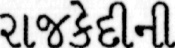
રાજકેદીની
